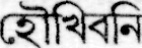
হৌখিবনি
